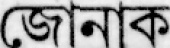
জোনাক
